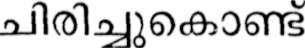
ചിരിച്ചുകൊണ്ട്
